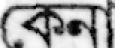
কেনা
